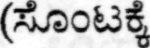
(ಸೊಂಟಕ್ಕೆ
